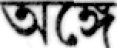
অঙ্গে
